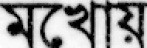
মখোয়
